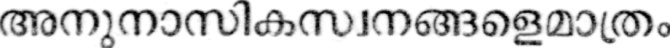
അനുനാസികസ്വനങ്ങളെമാത്രം
